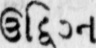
ઉદ્વિગ્ન
